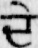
ਦੇ
